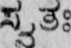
ಸ್ವತಃ
